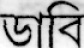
ডাবি
